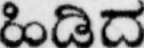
ಹಿಡಿದ
